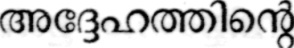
അദ്ദേഹത്തിന്റെ
